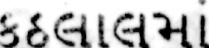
કઠલાલમાં
